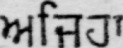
ਅਜਿਹਾ
